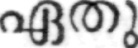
ഏതു
